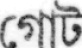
গোট
